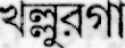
খল্লুরগা
